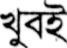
খুবই
